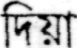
দিয়া
